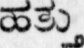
ಹತ್ತು
